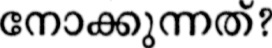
നോക്കുന്നത്?
